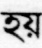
হয়
